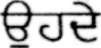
ਉਹਦੇ
